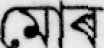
মোৰ
